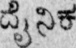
ದೈನಿಕ
